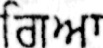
ਗਿਆ
